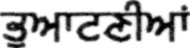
ਭੁਆਟਣੀਆਂ
